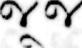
જૂજ
